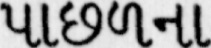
પાછળના
